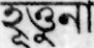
হূত্তুনা
